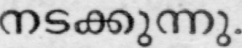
നടക്കുന്നു.
